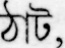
ঠাট,
